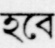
হবে
